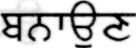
ਬਨਾਉਣ
